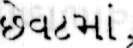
છેવટમાં,
